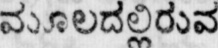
ಮೂಲದಲ್ಲಿರುವ
